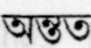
অন্তত
